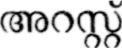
അറസ്റ്റ്
